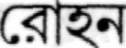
রোহন
